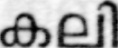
കലി
